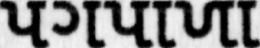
પગપાખા
